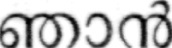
ഞാന്‍
